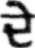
ਦੇ
